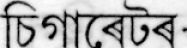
চিগাৰেটৰ
